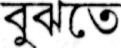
বুঝতে
